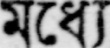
মধ্যে
